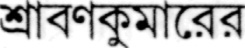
শ্রাবণকুমারের
